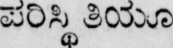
ಪರಿಸ್ಥಿತಿಯೂ
